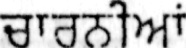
ਚਾਰਨੀਆਂ
